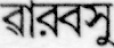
ৱারবসু
